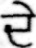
ਦੇ
